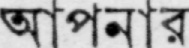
আপনার
